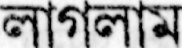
লাগলাম
